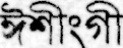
ঈশীংগী
